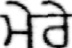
ਮੇਰੇ
